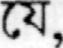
যে,
